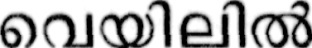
വെയിലില്‍
